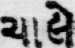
ચાલે
